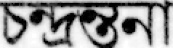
চন্দ্রন্তনা
